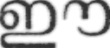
ഈ
